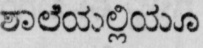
ಶಾಲೆಯಲ್ಲಿಯೂ
